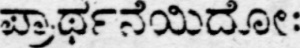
ಪ್ರಾರ್ಥನೆಯಿದೋ:
